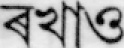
ৰখাও
